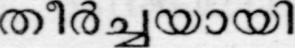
തീര്‍ച്ചയായി
